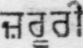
ਜ਼ਰੂਰੀ
